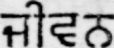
ਜੀਵਨ
